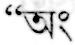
“অং
